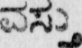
ವಸ್ತು
